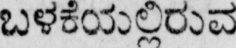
ಬಳಕೆಯಲ್ಲಿರುವ
